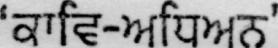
'ਕਾਵਿ-ਅਧਿਅਨ''
